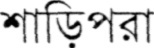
শাড়িপরা
